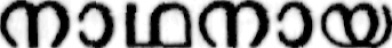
നാഥനായ
